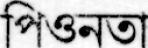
পিওনতা
